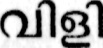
വിളി
